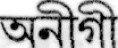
অনীগী
